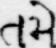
તમે
